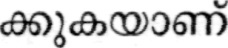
ക്കുകയാണ്
